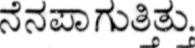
ನೆನಪಾಗುತ್ತಿತ್ತು.
